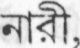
নারী,
